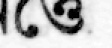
নত্তে
